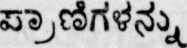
ಪ್ರಾಣಿಗಳನ್ನು
